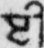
ਈ
